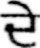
ਦੇ
